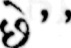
છે"
